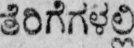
ತೆರಿಗೆಗಳಲ್ಲಿ
